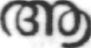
ആ
